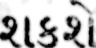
શકશે
